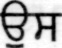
ਉਸ
